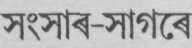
সংসাৰ-সাগৰে
